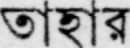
তাহার
